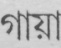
গায়া
